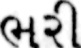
ભરી
